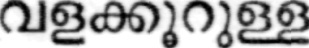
വളക്കൂറുള്ള
